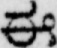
ಈ
